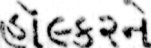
હૉલ્કરને
